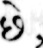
છે,
